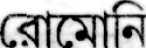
রোমোনি
